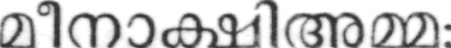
മീനാക്ഷിഅമ്മ:
